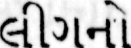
લીગનો
